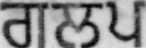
ਗਲਪ
